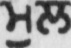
ਮੁਲ
